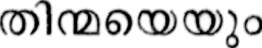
തിന്മയെയും
